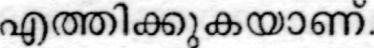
എത്തിക്കുകയാണ്.
